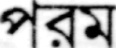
পরম
